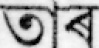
তাৰ
